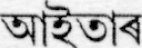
আইতাৰ
